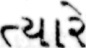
ત્યારે
